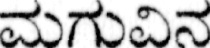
ಮಗುವಿನ
